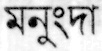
মনুংদা
